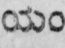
ಯಂ
